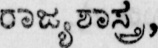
ರಾಜ್ಯಶಾಸ್ತ್ರ,
